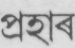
প্ৰহাৰ
